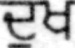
ਦੁਖ
